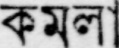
কমলা
